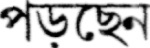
পড়ছেন
